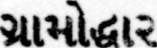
ગ્રામોદ્ધાર
